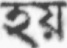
হয়
